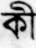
কী
